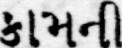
કામની
